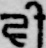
ਵੀ
